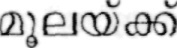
മൂലയ്ക്ക്
